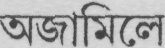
অজামিলে
